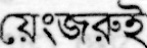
য়েংজরুই
